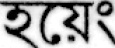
হয়েং
